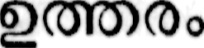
ഉത്തരം
